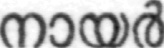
നായര്‍
